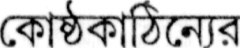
কোষ্ঠকাঠিন্যের
